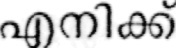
എനിക്ക്
